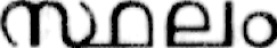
സ്ഥലം
